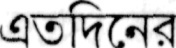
এতদিনের
